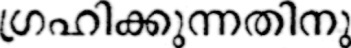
ഗ്രഹിക്കുന്നതിനു
